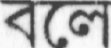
বলে
